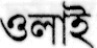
ওলাই
